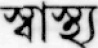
স্বাস্হ্য
